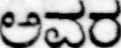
ಅವರ
